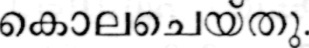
കൊലചെയ്തു.
